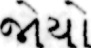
જોયો
